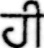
ਹੀ
